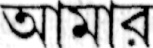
আমার
